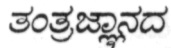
ತಂತ್ರಜ್ಞಾನದ
